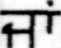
ਜਾਂ
